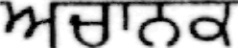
ਅਚਾਨਕ
